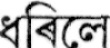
ধৰিলে
